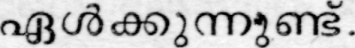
ഏള്‍ക്കുന്നുണ്ട്.
